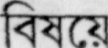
বিষয়ে
